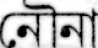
নৌনা
